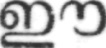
ഈ
